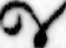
જ
